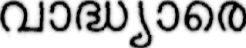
വാദ്ധ്യാരെ
